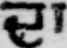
ਦਾ
